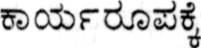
ಕಾರ್ಯರೂಪಕ್ಕೆ
